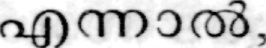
എന്നാല്‍,
